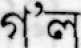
গ'ল
